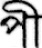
পী
